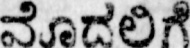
ಮೊದಲಿಗೆ
